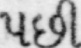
પછી
